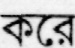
করে
